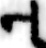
ન
